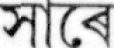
সাৰে
